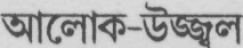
আলোক-উজ্জ্বল
